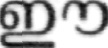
ഈ
